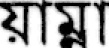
য়াম্না
